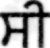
ਸੀ
